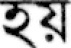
হয়
